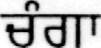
ਚੰਗਾ
